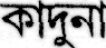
কাদুনা
